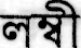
লম্বী
